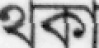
থকা
